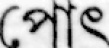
পোৎ
